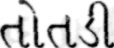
તોતડી
